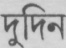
দুদিন
